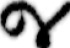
જ
